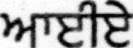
ਆਈਏ
